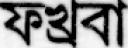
ফখ্রবা
